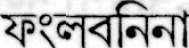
ফংলবনিনা
